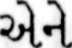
એને
